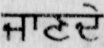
ਜਾਣਦੇ
